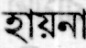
হায়না
